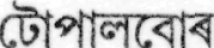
টোপালবোৰ
